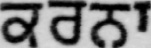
ਕਰਨਾ
